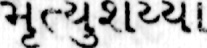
મૃત્યુશય્યા
